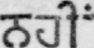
ਨਹੀਂ
